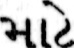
માટે
